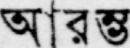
আরম্ভ
